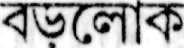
বড়লোক
